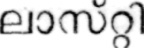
ലാസ്റ്റി
